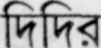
দিদির
